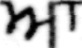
ਆ
